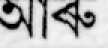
আৰু
